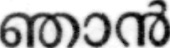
ഞാന്‍
